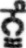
ਨੂੰ
